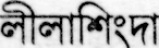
লীলাশিংদা
